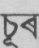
চূৰ
